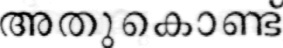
അതുകൊണ്ട്
